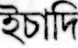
ইচাদি
